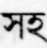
সহ
